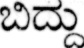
ಬಿದ್ದು
